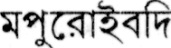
মপুরোইবদি
